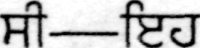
ਸੀ---ਇਹ
